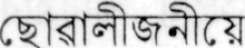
ছোৱালীজনীয়ে
